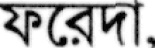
ফরেদা,
